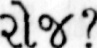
રોજ?
